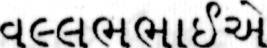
વલ્લભભાઈએ
